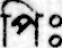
পিঃ
